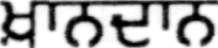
ਖ਼ਾਨਦਾਨ
